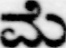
ಮೆ
